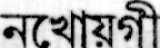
নখোয়গী
